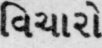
વિચારો
